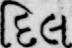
દિલ
